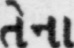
તેના
